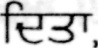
ਦਿਤਾ,
